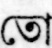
তো
